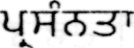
ਪ੍ਰਸੰਨਤਾ
